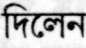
দিলেন
